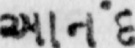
આનંદ
